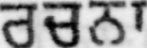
ਰਚਨਾ
